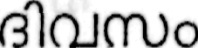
ദിവസം
